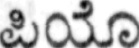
ಪಿಯೊ
